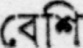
বেশি
